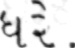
ધરે.
